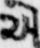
એ
